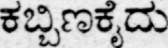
ಕಬ್ಬಿಣಕೈದು
